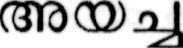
അയച്ച
